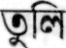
তুলি
